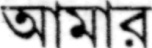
আমার
